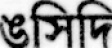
ঙসিদি
